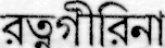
রত্নগীরিনা
